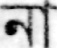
না
